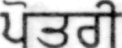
ਪੋਤਰੀ
